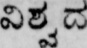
ವಿಶ್ವದ
